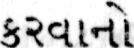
કરવાનો
